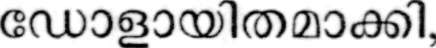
ഡോളായിതമാക്കി,
